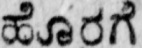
ಹೊರಗೆ
